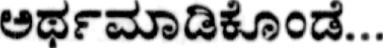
ಅರ್ಥಮಾಡಿಕೊಂಡೆ...
